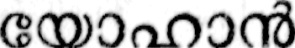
യോഹാന്‍
